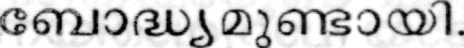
ബോദ്ധ്യമുണ്ടായി.
